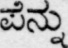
ಪೆನ್ನು
